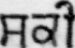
ਸਕੀ
